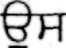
ਉਸ
